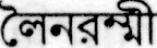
লৈনরম্মী
